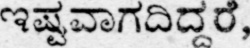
ಇಷ್ಟವಾಗದಿದ್ದರೆ,
